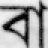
বা
